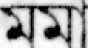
মমা
